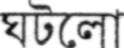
ঘটলো
